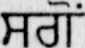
ਸਗੋਂ
